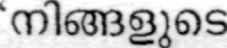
‘നിങ്ങളുടെ
